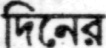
দিনের
